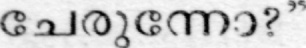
ചേരുന്നോ?”
